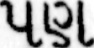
પણ
